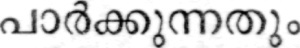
പാര്‍ക്കുന്നതും
